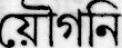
য়ৌগনি
